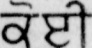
ਕੋਈ
